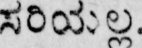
ಸರಿಯಲ್ಲ.
